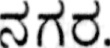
ನಗರ.
